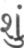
શું
